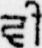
ਵੀ
